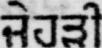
ਜੇਹੜੀ
